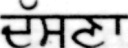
ਦੱਸਣਾ
